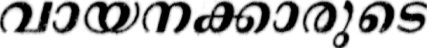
വായനക്കാരുടെ
